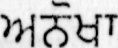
ਅਨੋਖਾ
